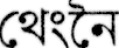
থেংনৈ
